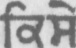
ਕਿਸੇ
